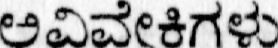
ಅವಿವೇಕಿಗಳು
